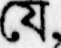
যে,
